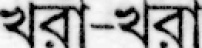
খরা-খরা
